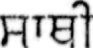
ਸਾਥੀ
